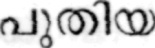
പുതിയ
